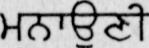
ਮਨਾਉਣੀ
